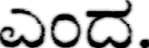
ಎಂದ.
